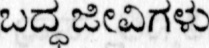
ಬದ್ಧಜೀವಿಗಳು
